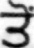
ਤੋਂ
